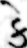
કે
